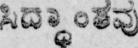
ಸಿದ್ದಾಂತವು
